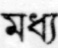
মধ্য
